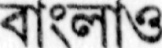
বাংলাও
